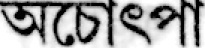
অচোৎপা
